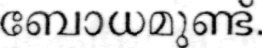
ബോധമുണ്ട്.
